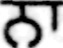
ਨਾ
